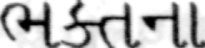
ભક્તના
